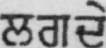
ਲਗਦੇ
